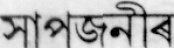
সাপজনীৰ
